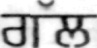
ਗੱਲ
